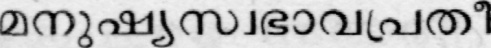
മനുഷ്യസ്വഭാവപ്രതീ
